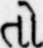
તો
